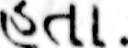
હતા.
